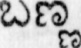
ಬಣ್ಣ
